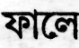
ফালে
